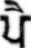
ਪੈ
